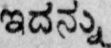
ಇದನ್ನು
